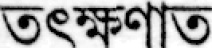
তৎক্ষণাত
